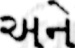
અને
